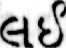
લઈ
